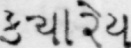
ક્યારેય
